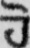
ਹੋ
